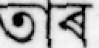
তাৰ
